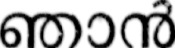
ഞാന്‍
